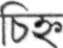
চিহ্ন
